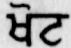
ਖੋਟ
